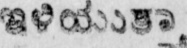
ಇಳಿಯುತ್ತಾ
